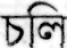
চলি
